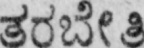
ತರಬೇತಿ
